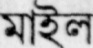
মাইল
